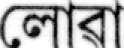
লোৱা
